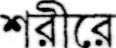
শরীরে
